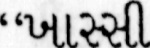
"ખાસ્સી
